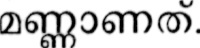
മണ്ണാണത്.
